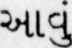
આવું
